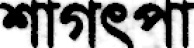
শাগৎপা
